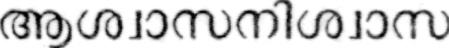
ആശ്വാസനിശ്വാസ
